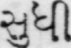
સુધી
